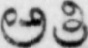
ಅತಿ
